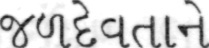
જળદેવતાને
